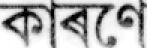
কাৰণে
